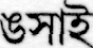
ঙসাই
